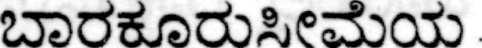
ಬಾರಕೂರುಸೀಮೆಯ
